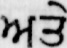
ਅਤੇ
